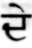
ਦੇ
